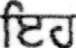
ਇਹ
